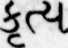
કૃત્ય
